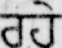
ਰਹੇ
